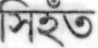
সিহঁত
